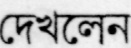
দেখলেন
